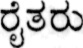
ರೈತರು
